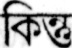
কিন্তু
